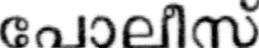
പോലീസ്
